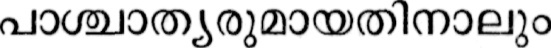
പാശ്ചാത്യരുമായതിനാലും
